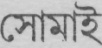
সোমাই
